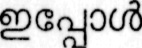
ഇപ്പോള്‍
